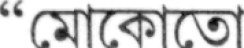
"মোকোতো
